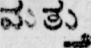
ಮತ್ತು
